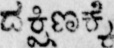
ದಕ್ಷಿಣಕ್ಕೆ
